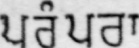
ਪਰੰਪਰਾ
